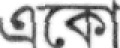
একো
